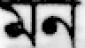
মন
